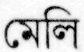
মেলি
